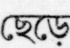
ছেড়ে
